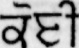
ਕੋਈ
